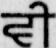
ਵੀ
